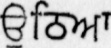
ਉਠਿਆ
